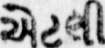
એટલી
